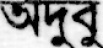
অদুবু
